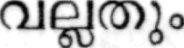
വല്ലതും
